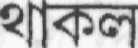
থাকল
